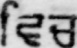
ਵਿਚ
